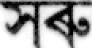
সৰু
